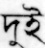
দুই
